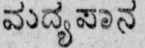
ಮದ್ಯಪಾನ
